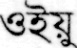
ওইয়ু
